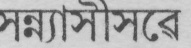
সন্ন্যাসীসৱে
